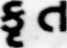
કૃત
